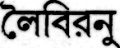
লৈবিরনু
